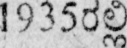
1935ರಲ್ಲಿ
